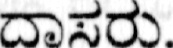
ದಾಸರು.
